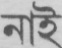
নাই
